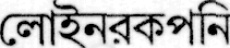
লোইনরকপনি
